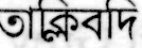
তাক্লিবদি
